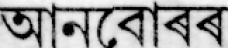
আনবোৰৰ
